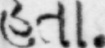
હતા.
